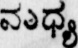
ಮಧ್ಯ
